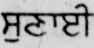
ਸੁਣਾਈ
